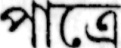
পাত্রে
